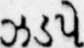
ઝડપે
